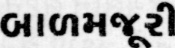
બાળમજૂરી
